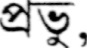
প্রভু,
